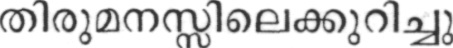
തിരുമനസ്സിലെക്കുറിച്ചു
